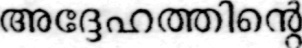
അദ്ദേഹത്തിന്റെ
